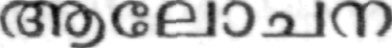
ആലോചന
